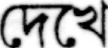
দেখে
